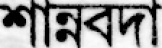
শান্নবদা
